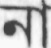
না
